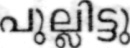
പുല്ലിട്ടു
